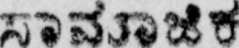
ಸಾಮಾಜಿಕ
